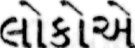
લોકોએ
